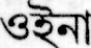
ওইনা
